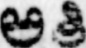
ಅತಿ
